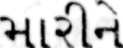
મારીને
